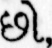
છો,
